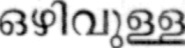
ഒഴിവുള്ള
